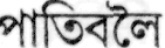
পাতিবলৈ
